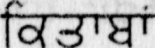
ਕਿਤਾਬਾਂ
